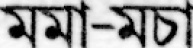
মমা-মচা
